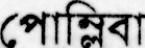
পোম্লিবা
